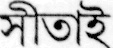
সীতাই
